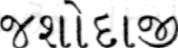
જશોદાજી
